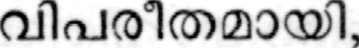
വിപരീതമായി,
